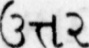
ઉત્તર
